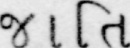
જાતિ
